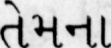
તેમના
